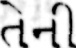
તેની
